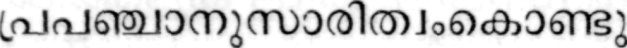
പ്രപഞ്ചാനുസാരിത്വംകൊണ്ടു
